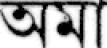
অমা
